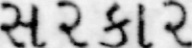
સરકાર
